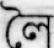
লৈ
